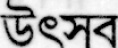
উৎসব
